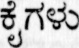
ಕೈಗಳು
